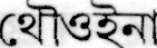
থৌওইনা
